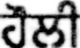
ਹੌਲੀ
